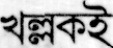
খল্লকই
